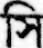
সি
